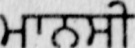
ਮਾਨਸੀ
